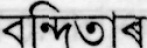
বন্দিতাৰ
